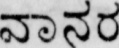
ವಾನರ
